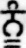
ਨੂੰ
